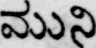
ಮುನಿ
